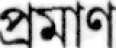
প্রমাণ
